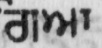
ਗਿਆ
